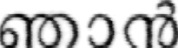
ഞാന്‍
